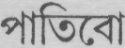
পাতিবো
